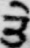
ਤੇ
